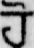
ਹੋ
